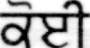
ਕੋਈ
